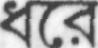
ধরে
